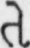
તે
